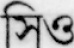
সিও
